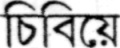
চিবিয়ে
